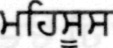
ਮਹਿਸੂਸ
